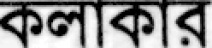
কলাকার
